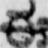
ಈ
